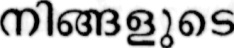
നിങ്ങളുടെ
